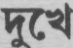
দুখে
